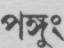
পঙ্গুং
